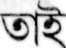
তাই
